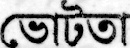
ভোটতা
